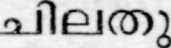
ചിലതു
